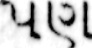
પણ
